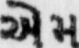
એમ
